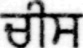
ਚੀਸ
